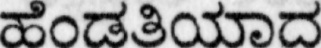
ಹೆಂಡತಿಯಾದ
